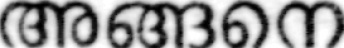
അങ്ങനെ
